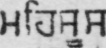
ਮਹਿਸੂਸ
